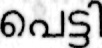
പെട്ടി
